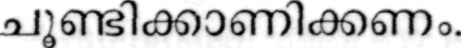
ചൂണ്ടിക്കാണിക്കണം.
